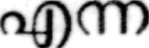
എന്ന
